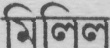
মিলিল
